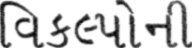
વિકલ્પોની
